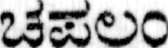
ಚಪಲಂ
